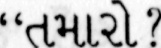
"તમારો?
